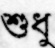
শুধু
